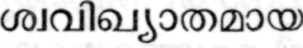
ശ്വവിഖ്യാതമായ
